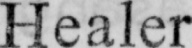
Healer
